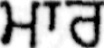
ਮਾਰ
